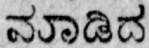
ಮಾಡಿದ
